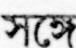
সঙ্গে
